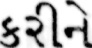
કરીને
